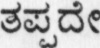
ತಪ್ಪದೇ
